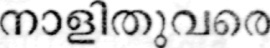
നാളിതുവരെ
